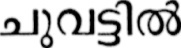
ചുവട്ടില്‍
